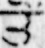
ਤੋਂ
